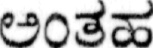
ಅಂತಹ
